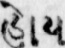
હોય
